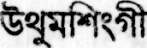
উথুমশিংগী
